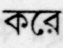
করে
